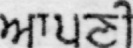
ਆਪਣੀ
